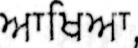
ਆਖਿਆ,
